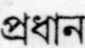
প্রধান
